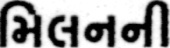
મિલનની
